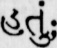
હતું;
